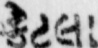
કેટલા
